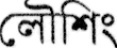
লৌশিং
